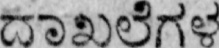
ದಾಖಲೆಗಳ
